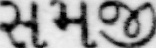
સમજી
